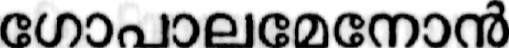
ഗോപാലമേനോന്‍
